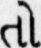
તો
